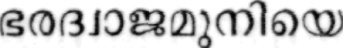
ഭരദ്വാജമുനിയെ
